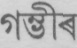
গম্ভীৰ
